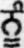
ਨੂੰ
